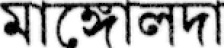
মাঙ্গোলদা
